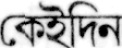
কেইদিন
